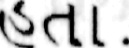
હતા.
